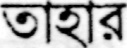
তাহার
